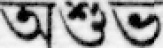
অশুভ
